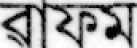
ৱাফম
